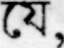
যে,
